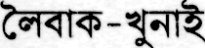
লৈবাক-খুনাই
